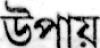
উপায়
